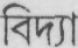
বিদ্যা
